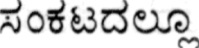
ಸಂಕಟದಲ್ಲೂ
